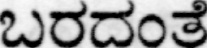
ಬರದಂತೆ
